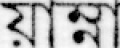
য়াম্না
